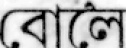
বোলে
